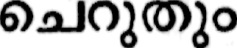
ചെറുതും
